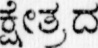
ಕ್ಷೇತ್ರದ
